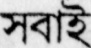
সবাই
